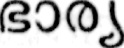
ഭാര്യ
